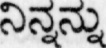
ನಿನ್ನನ್ನು
